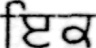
ਇਕ
